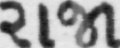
રાજા
